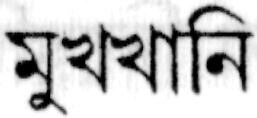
মুখখানি
